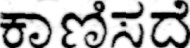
ಕಾಣಿಸದೆ
